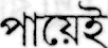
পায়েই
